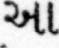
આ
